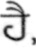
ਹੈ,
